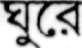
ঘুরে
